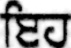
ਇਹ
